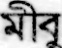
মীবু
